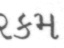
રકમ
